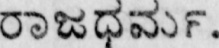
ರಾಜಧರ್ಮ.
